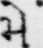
મેં
